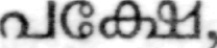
പക്ഷേ,
